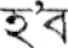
হ'ব
